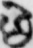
છે
